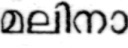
മലിനാ
